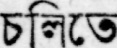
চলিতে
